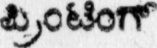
ಪ್ರಿಂಟಿಂಗ್
